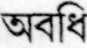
অবধি
